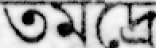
তমদ্রে
